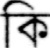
কি
